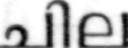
ചില
